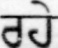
ਰਹੇ
